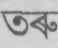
তৰু
